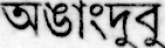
অঙাংদুবু
